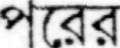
পরের
